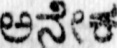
ಅನೇಕ
